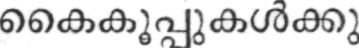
കൈകൂപ്പുകള്‍ക്കു
